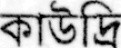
কাউদ্রি
